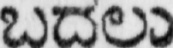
ಬದಲು
